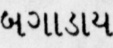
બગાડાય
